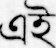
এই
